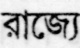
রাজ্যে
